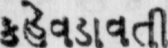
કહેવડાવતી
